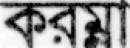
করম্না
